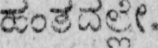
ಹಂತದಲ್ಲೇ.
